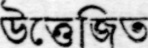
উত্তেজিত
